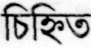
চিহ্নিত
